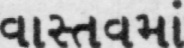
વાસ્તવમાં
